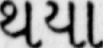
થયા
